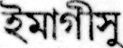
ইমাগীসু
